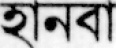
হানবা
